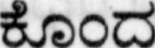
ಕೊಂದ
